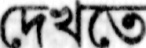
দেখতে
